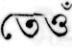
তেওঁ
